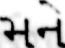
મને
